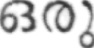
ഒരു
